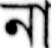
না
